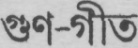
গুণ-গীত
